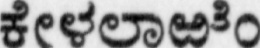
ಕೇಳಲಾಱೆಂ
